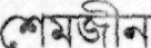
শেমজিন
